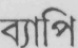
ব্যাপি
